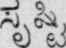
ಸೃಷ್ಟಿ
